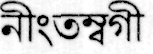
নীংতম্বগী
